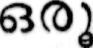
ഒരൂ
